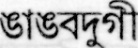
ঙাঙবদুগী
